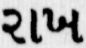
રાખ
